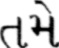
તમે
